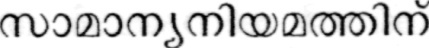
സാമാന്യനിയമത്തിന്
